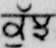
ਕੁੱਝ
